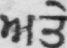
ਅਤੇ
